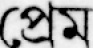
প্রেম
